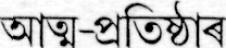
আত্ম-প্রতিষ্ঠাৰ
